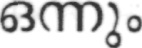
ഒന്നും
